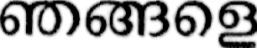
ഞങ്ങളെ
